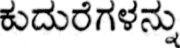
ಕುದುರೆಗಳನ್ನು
